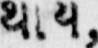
થાય,
